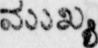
ಮುಖ್ಯ
